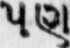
પણ
